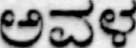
ಅವಳ
